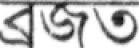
ব্রজত
